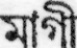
মাগী
